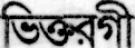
ভিক্তরগী
